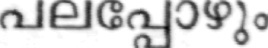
പലപ്പോഴും
